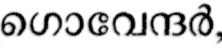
ഗൊവേന്ദര്‍,
